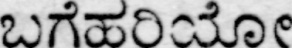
ಬಗೆಹರಿಯೋ
